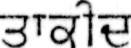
ਤਾਕੀਦ
